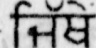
ਜਿੱਥੇ
